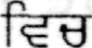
ਵਿਚ
